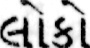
લોકો
